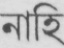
নাহি
